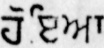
ਹੋਇਆ
